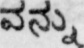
ವನ್ನು
